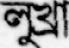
লুখ্রা
